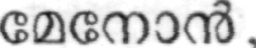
മേനോന്‍,
